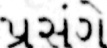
પ્રસંગે
